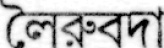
লৈরুবদা
